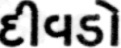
દીવડો
